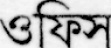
ওফিস
